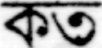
কত
